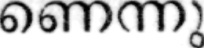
ണെന്നു
